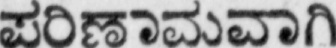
ಪರಿಣಾಮವಾಗಿ
